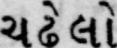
ચઢેલો
